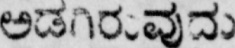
ಅಡಗಿರುವುದು
